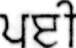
ਪਈ
